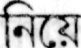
নিয়ে
